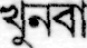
খুনবা
